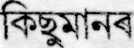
কিছুমানৰ
